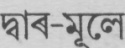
দ্বাৰ-মূলে
